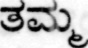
ತಮ್ಮ
